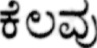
ಕೆಲವು
